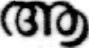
ആ
